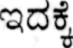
ಇದಕ್ಕೆ
